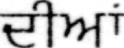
ਦੀਆਂ
